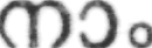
നാം
